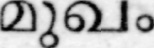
മുഖം
